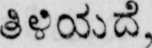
ತಿಳಿಯದೆ,
